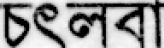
চৎলবা
